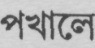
পখালে
